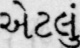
એટલું
